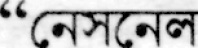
“নেসনেল
